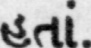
હતાં.
